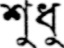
শুধু
